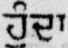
ਹੁੰਦਾ
